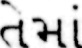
તેમાં
